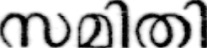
സമിതി
